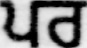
ਪਰ
